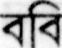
ববি
